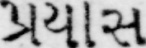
પ્રયાસ
